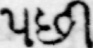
પછી
